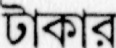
টাকার
